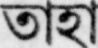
তাহা
